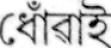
ধোঁৱাই
